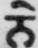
ਨੇ
